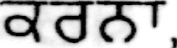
ਕਰਨਾ,
